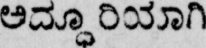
ಅದ್ದೂರಿಯಾಗಿ
